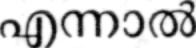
എന്നാല്‍
